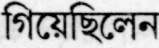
গিয়েছিলেন
